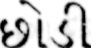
છોડી
